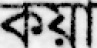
কয়া
